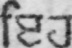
ਇਹ
